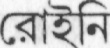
রোইনি
